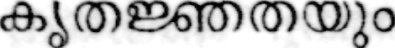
കൃതജ്ഞതയും
